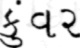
કુંવર
